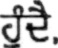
ਹੁੰਦੈ,
